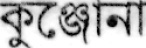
কুঞ্জোনা
